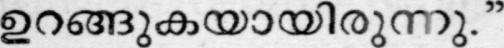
ഉറങ്ങുകയായിരുന്നു."
